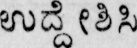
ಉದ್ದೇಶಿಸಿ
